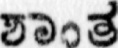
ಶಾಂತ
